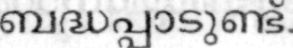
ബദ്ധപ്പാടുണ്ട്.
